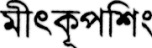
মীৎকুপশিং
